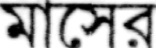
মাসের
